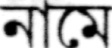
নামে
